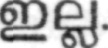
ഇല്ല.
